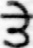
ਤੇ
